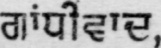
ਗਾਂਧੀਵਾਦ,
